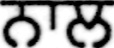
ਨਾਲ
